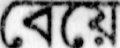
বেয়ে
